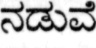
ನಡುವೆ
